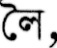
লৈ,
